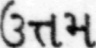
ઉત્તમ
